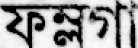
ফম্লগা
